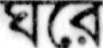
ঘরে
